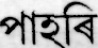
পাহৰি
